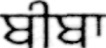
ਬੀਬਾ
